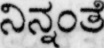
ನಿನ್ನಂತೆ
